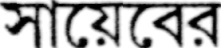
সায়েবের
